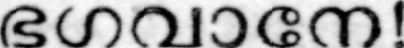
ഭഗവാനേ!
